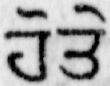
ਹੋਤੇ
